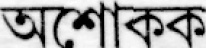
অশোকক
